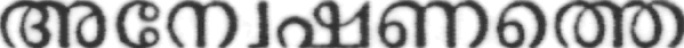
അന്വേഷണത്തെ
